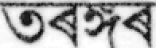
তৰঙ্গৰ
